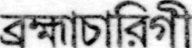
ব্রহ্মাচারিগী
